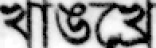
খাঙখ্রে
